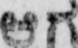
ಆಗ
